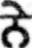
ਨੇ
